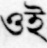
ওই
